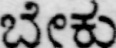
ಬೇಕು
